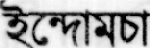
ইন্দোমচা
